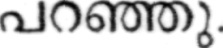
പറഞ്ഞു.
